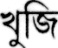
খুজি
